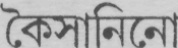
কৈসানিনো
